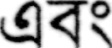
এবং
